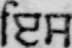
ਇਸ
